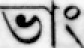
ভাং
